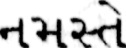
નમસ્તે
